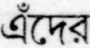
এঁদের
